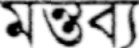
মন্তব্য
